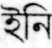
ইনি
